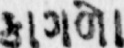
કાગળો
